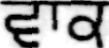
ਵਾਕ
